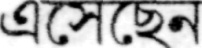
এসেছেন
